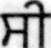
ਸੀ
